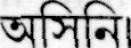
অসিনি।
